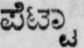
ಪೆಟ್ಟಾ
